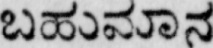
ಬಹುಮಾನ
